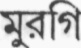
মুরগি
